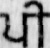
ਪੀ
